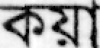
কয়া
